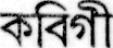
কবিগী
